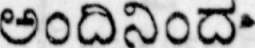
ಅಂದಿನಿಂದ
